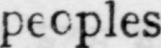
peoples
